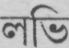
লভি
